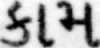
કામ
